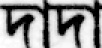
দাদা
